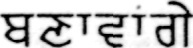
ਬਣਾਵਾਂਗੇ
